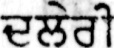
ਦਲੇਰੀ
